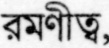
রমণীত্ব,
